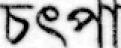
চৎপা
